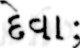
દેવા;
